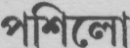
পশিলো
